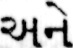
અને
